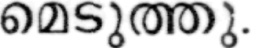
മെടുത്തു.
